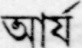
আর্য
